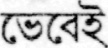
ভেবেই
